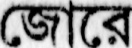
জোরে
